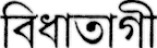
বিধাতাগী
